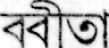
ববীতা
